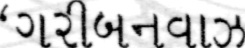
'ગરીબનવાઝ
